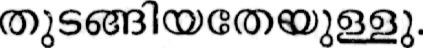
തുടങ്ങിയതേയുള്ളു.
